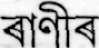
ৰাণীৰ
